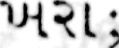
ખરા;
